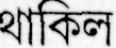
থাকিল
